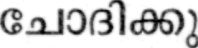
ചോദിക്കു
